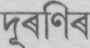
দূৰণিৰ
